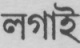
লগাই
